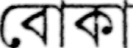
বোকা
